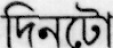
দিনটো
